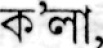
ক'লা,
